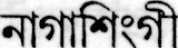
নাগাশিংগী
